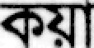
কয়া
